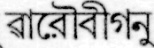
ৱারৌবীগনু
